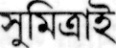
সুমিত্রাই
